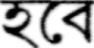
হবে
